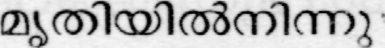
മൃതിയില്‍നിന്നു
